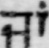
ਜਾਂ
